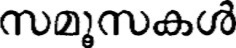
സമൂസകള്‍
